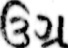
ઉગ્ર
